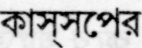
কাস্সপের
